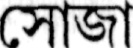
সোজা
